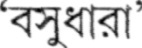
‘বসুধারা’
